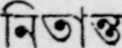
নিতান্ত
